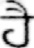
ਹੈ
